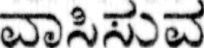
ವಾಸಿಸುವ
